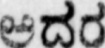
ಅದರ
